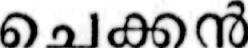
ചെക്കന്‍
